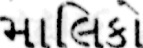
માલિકો
